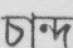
চান্দ
